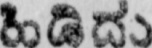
ಹಿಡಿದು
